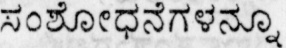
ಸಂಶೋಧನೆಗಳನ್ನೂ
